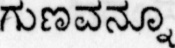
ಗುಣವನ್ನೂ
